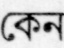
কেন
